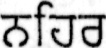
ਨਹਿਰ
